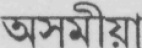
অসমীয়া
